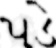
પડે
